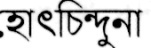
হোৎচিন্দুনা
